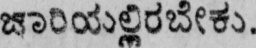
ಜಾರಿಯಲ್ಲಿರಬೇಕು.
